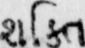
શક્તિ
